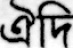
ঐদি
